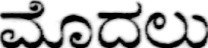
ಮೊದಲು
